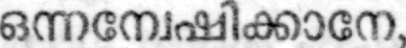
ഒന്നന്വേഷിക്കാനേ,
